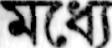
মধ্যে
